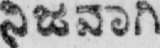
ನಿಜವಾಗಿ
